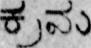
ಕ್ರಮ
